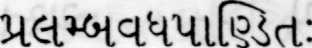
પ્રલમ્બઘપાણ્ડિતઃ
